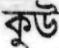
কুউ
